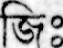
জিঃ
